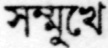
সম্মুখে
